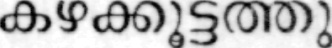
കഴക്കൂട്ടത്തു
